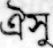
ঐসু
